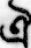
ঐ
